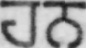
ਹਨ
